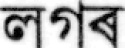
লগৰ
